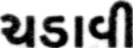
ચડાવી
